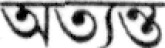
অত্যন্ত
